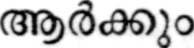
ആര്‍ക്കും
